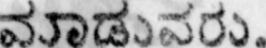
ಮಾಡುವರು.
